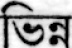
ভিন্ন
